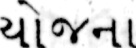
યોજના
